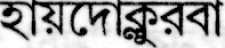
হায়দোক্লুরবা
